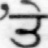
'ਤੇ
